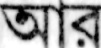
আর
